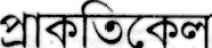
প্রাকতিকেল
